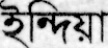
ইন্দিয়া
